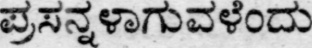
ಪ್ರಸನ್ನಳಾಗುವಳೆಂದು
